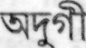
অদুগী
